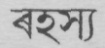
ৰহস্য
